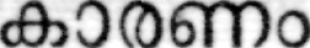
കാരണം
